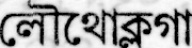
লৌথোক্লগা
